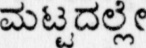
ಮಟ್ಟದಲ್ಲೇ
